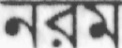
নরম
